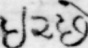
ઇચ્છે
